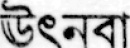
ঊৎনবা
